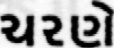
ચરણે
